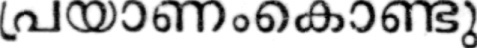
പ്രയാണംകൊണ്ടു
